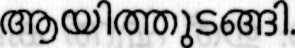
ആയിത്തുടങ്ങി.
